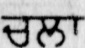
ਚਲਾ
